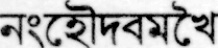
নংহৌদবমখৈ
